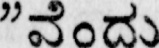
ವೆಂದು
